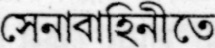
সেনাবাহিনীতে
